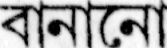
বানানো
